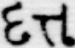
દત્ત
